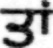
ਤਾਂ
